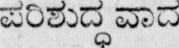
ಪರಿಶುದ್ಧವಾದ
